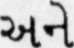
અને
